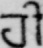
ਹੀ
